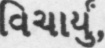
વિચાર્યું,
